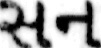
સન
